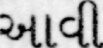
આવી
